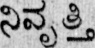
ನಿವೃತ್ತಿ
